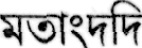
মতাংদদি
